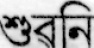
শুৱনি
